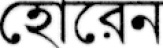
হোরেন
